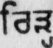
ਰਿੜ੍ਹ
